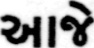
આજે
